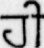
ਹੀ
